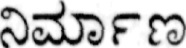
ನಿರ್ಮಾಣ
